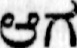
ಆಗ
